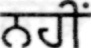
ਨਹੀਂ
